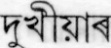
দুখীয়াৰ
